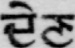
ਦੇਣ
